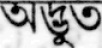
অদ্ভুত
